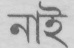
নাই
